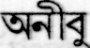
অনীবু
